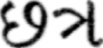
છત્ર
